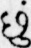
છું
